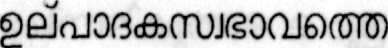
ഉല്പാദകസ്വഭാവത്തെ
